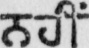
ਨਹੀਂ
